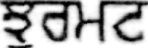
ਝੁਰਮਟ
